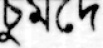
চুমদে
